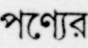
পণ্যের
